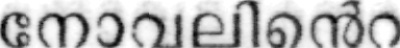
നോവലിന്റെ
